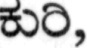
ಕುರಿ,
